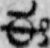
ಈ
